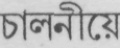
চালনীয়ে
